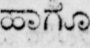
ಹಾಗೂ
